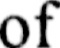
of
